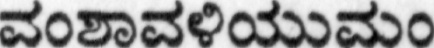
ವಂಶಾವಳಿಯುಮಂ
